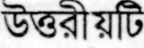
উত্তরীয়টি
